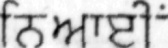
ਨਿਆਈਂ
